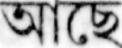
আছে
